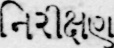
નિરીક્ષણ
